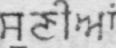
ਸੁਣੀਆਂ
